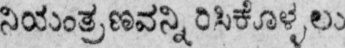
ನಿಯಂತ್ರಣವನ್ನಿರಿಸಿಕೊಳ್ಳಲು
